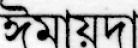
ঈমায়দা
